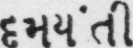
દમયંતી
